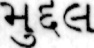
મુદ્લ
